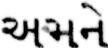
અમને
